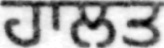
ਹਾਲਤ
